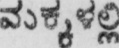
ಮಕ್ಕಳಲ್ಲಿ
